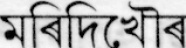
মৰিদিখৌৰ
